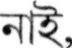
নাই,
